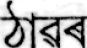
ঠাৱৰ
